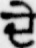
ਦੇ
